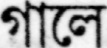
গালে
